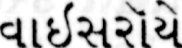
વાઇસરૉયે
